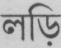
লড়ি
